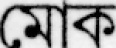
মোক
